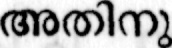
അതിനു
